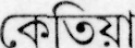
কেতিয়া
